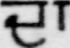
ਦਾ
